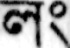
লং
